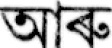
আৰু
